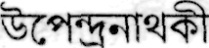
উপেন্দ্রনাথকী
